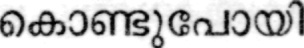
കൊണ്ടുപോയി
